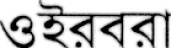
ওইরবরা
